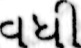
વધી
